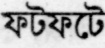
ফটফটে
